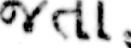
જતા,
